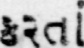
કરતાં
